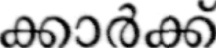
ക്കാര്‍ക്ക്
